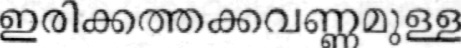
ഇരിക്കത്തക്കവണ്ണമുള്ള
